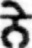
ਨੇ
